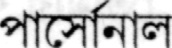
পার্সোনাল
